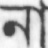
না
